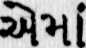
એમાં
